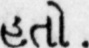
હતો.
